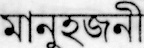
মানুহজনী
